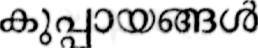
കുപ്പായങ്ങള്‍
